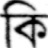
কি
